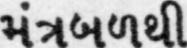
મંત્રબળથી
